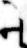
ને
